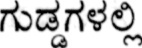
ಗುಡ್ಡಗಳಲ್ಲಿ
